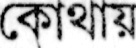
কোথায়
